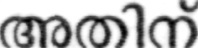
അതിന്
